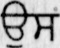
ਉਸ
